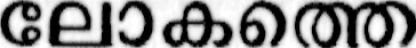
ലോകത്തെ
